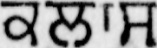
ਕਲਾਸ
